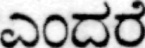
ಎಂದರೆ
